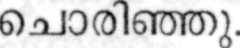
ചൊരിഞ്ഞു.
